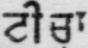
ਟੀਚਾ
